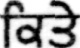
ਕਿਤੇ
